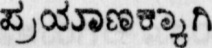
ಪ್ರಯಾಣಕ್ಕಾಗಿ
